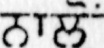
ਨਾਲੋਂ
